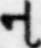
ન
